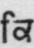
ਕਿ
